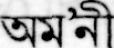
অম’নী
